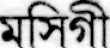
মসিগী
